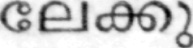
ലേക്കു
